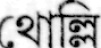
থোল্লি
